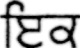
ਇਕ
